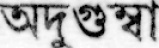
অদুগুম্বা
